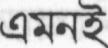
এমনই
